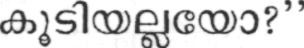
കൂടിയല്ലയോ?"
